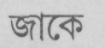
জাকে
